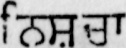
ਨਿਸ਼ਚਾ
